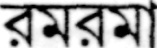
রমরমা
